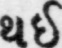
થઈ
